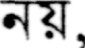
নয়,
